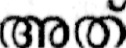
അത്
